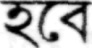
হবে
